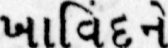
ખાવિંદને
